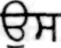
ਉਸ
